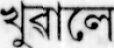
খুৱালে
